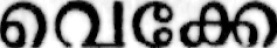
വെക്കേ
